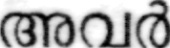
അവര്‍
